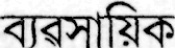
ব্যৱসায়িক
